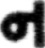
ન
